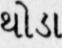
થોડા
